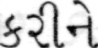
કરીને
